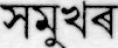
সমুখৰ
